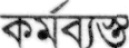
কর্মব্যস্ত
